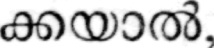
ക്കയാല്‍,
